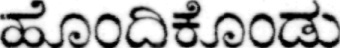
ಹೊಂದಿಕೊಂಡು
